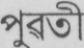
পুৱতী
